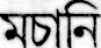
মচানি
